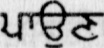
ਪਾਉਣ
